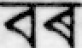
বৰ
